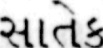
સાતેક
